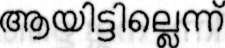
ആയിട്ടില്ലെന്ന്
